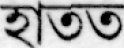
হাতত
